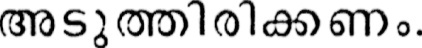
അടുത്തിരിക്കണം.
